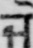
ਜੋ
